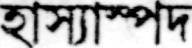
হাস্যাস্পদ
